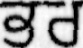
ਭਰ
